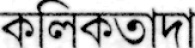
কলিকতাদা
